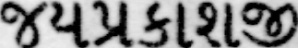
જયપ્રકાશજી
